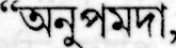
“অনুপমদা,
